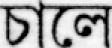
চালে
